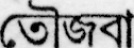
তৌজবা
